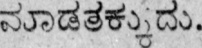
ಮಾಡತಕ್ಕುದು.
